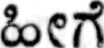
ಹೀಗೆ
